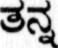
ತನ್ನ
